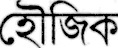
হৌজিক
